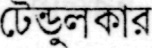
টেন্ডুলকার
